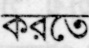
করতে
